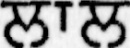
ਲਾਲ
